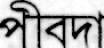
পীবদা
